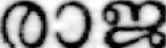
രാജ
